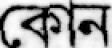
কোন
